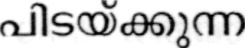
പിടയ്ക്കുന്ന
